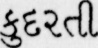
કુદરતી
